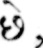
છે,
